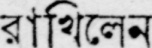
রাখিলেন
